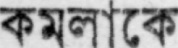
কমলাকে
